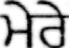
ਮੇਰੇ
